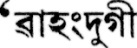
‘ৱাহংদুগী
